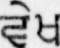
ਵੇਖ
